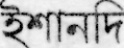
ইশানদি
